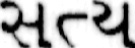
સત્ય
